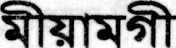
মীয়ামগী
